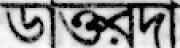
ডাক্তরদা
